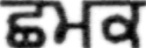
ਛਮਕ
